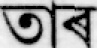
তাৰ
